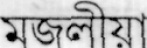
মজলীয়া
